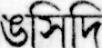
ঙসিদি
